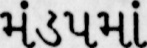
મંડપમાં
